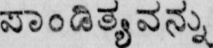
ಪಾಂಡಿತ್ಯವನ್ನು
